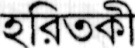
হরিতকী
